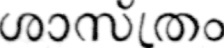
ശാസ്ത്രം
